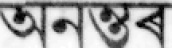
অনন্তৰ
